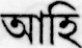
আহি
